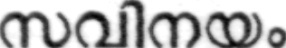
സവിനയം
